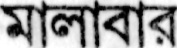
মালাবার
